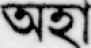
অহা
